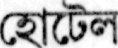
হোটেল
